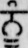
ਨੂੰ
